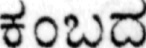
ಕಂಬದ
